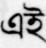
এই
